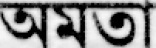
অমতা
